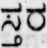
ಸ್ತರ
